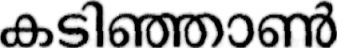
കടിഞ്ഞാണ്‍
